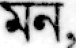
মন,
